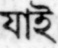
যাই
